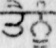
ਤੈਨੂੰ
